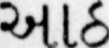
આઠ
